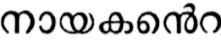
നായകന്റെ
